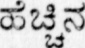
ಹೆಚ್ಚಿನ
